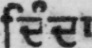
ਦਿੰਦਾ
